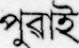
পুৱাই
